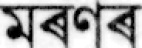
মৰণৰ
